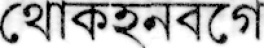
থোকহনবগে
